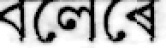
বলেৰে
